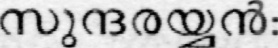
സുന്ദരയ്യന്‍:
